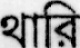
থারি
